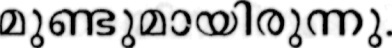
മുണ്ടുമായിരുന്നു.
